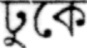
ঢুকে
